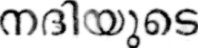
നദിയുടെ
